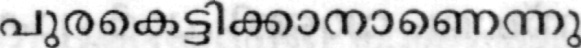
പുരകെട്ടിക്കാനാണെന്നു
